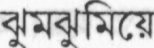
ঝুমঝুমিয়ে
